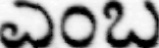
ಎಂಬ
